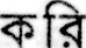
করি
